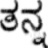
ತನ್ನ
